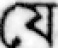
যে
